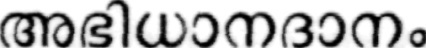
അഭിധാനദാനം
